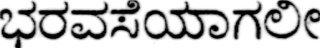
ಭರವಸೆಯಾಗಲೀ
